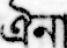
ঐনা
